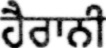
ਹੈਰਾਨੀ
